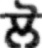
ਲੋ
